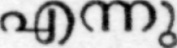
എന്നു
